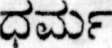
ಧರ್ಮ
